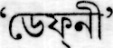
'ডেফ্‌নী'
